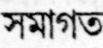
সমাগত
